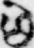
છે
